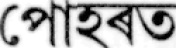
পোহৰত
